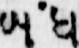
બંધ
